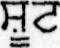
ਸ਼ੂਟ
